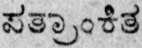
ಪತ್ರಾಂಕಿತ
